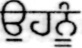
ਉਹਨੂੰ
